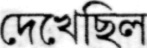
দেখেছিল
